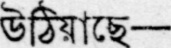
উঠিয়াছে—
